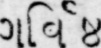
ગર્વિષ્ટ
